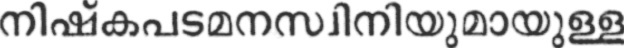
നിഷ്കപടമനസ്വിനിയുമായുള്ള
